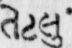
તેટલું
